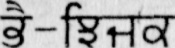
ਭੈ-ਝਿਜਕ
